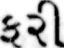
ફરી
